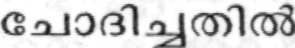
ചോദിച്ചതില്‍
